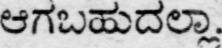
ಆಗಬಹುದಲ್ಲಾ.
